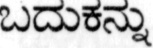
ಬದುಕನ್ನು
